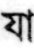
যা
